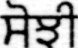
ਸੋਝੀ
